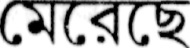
মেরেছে
